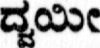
ದ್ವಯೀ
